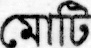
মোটি
